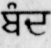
ਬੰਦ
